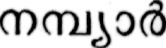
നമ്പ്യാര്‍
